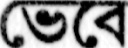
ভেবে
